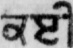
ਕਈ
